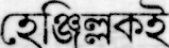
হেঞ্জিল্লকই
